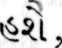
હશૈ,
